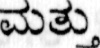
ಮತ್ತು
